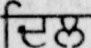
ਦਿਲ
